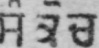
ਸੰਕੋਚ
